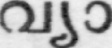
വ്യാ
